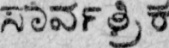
ಸಾರ್ವತ್ರಿಕ
